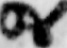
જ
